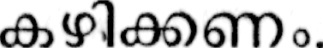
കഴിക്കണം.
